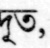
দূত,
